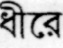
ধীরে
